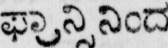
ಫ್ರಾನ್ಸಿನಿಂದ
